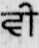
ਵੀ
